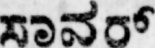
ಸಾವರ್
